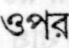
ওপর
